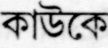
কাউকে
